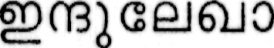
ഇന്ദുലേഖാ
